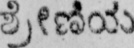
ಶ್ರೇಣಿಯ
